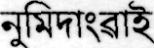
নুমিদাংৱাই
